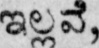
ಇಲ್ಲವೆ,
